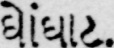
ઘોંઘાટ.
